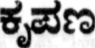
ಕೃಪಣ
